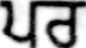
ਪਰ
